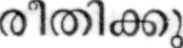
രീതിക്കു
